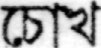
চোখ
